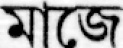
মাজে
